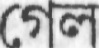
গেল
